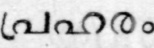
പ്രഹരം
